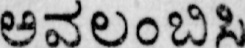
ಅವಲಂಬಿಸಿ
